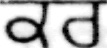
ਕਰ
